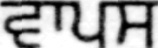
ਵਾਪਸ
